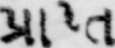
પ્રાપ્ત
